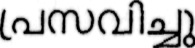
പ്രസവിച്ചു
